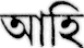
আহি
